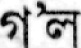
গ'ল
